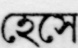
হেসে
